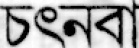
চৎনবা
